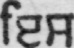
ਇਸ
